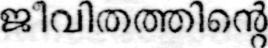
ജീവിതത്തിന്റെ
